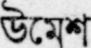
উমেশ
